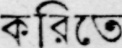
করিতে
